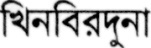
খিনবিরদুনা
